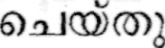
ചെയ്തു
